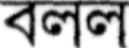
বলল
